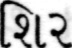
શિર
